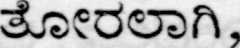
ತೋರಲಾಗಿ,
